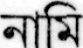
নামি
